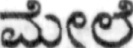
ಮೇಲೆ
